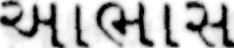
આભાસ
